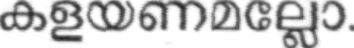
കളയണമല്ലോ.
